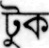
টুক
